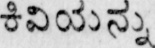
ಕಿವಿಯನ್ನು
